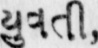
યુવતી,
